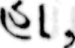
હા,
